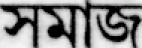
সমাজ
